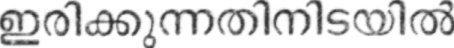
ഇരിക്കുന്നതിനിടയില്‍
